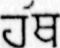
ਹੱਥ
